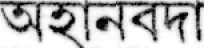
অহানবদা
